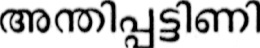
അന്തിപ്പട്ടിണി
